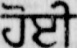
ਹੋਈ
